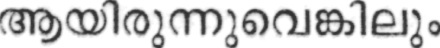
ആയിരുന്നുവെങ്കിലും
